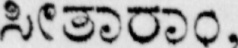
ಸೀತಾರಾಂ,
